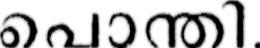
പൊന്തി.
